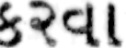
કરવા
